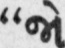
"જો
